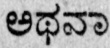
ಅಥವಾ
